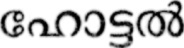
ഹോട്ടല്‍
